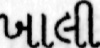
ખાલી
